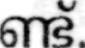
ണ്ട്.
